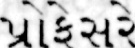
પ્રોફેસરે
